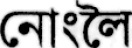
নোংলৈ
